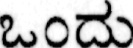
ಒಂದು
